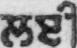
ਲਈ
